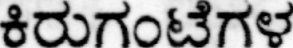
ಕಿರುಗಂಟೆಗಳ
